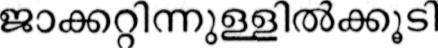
ജാക്കറ്റിന്നുള്ളില്‍ക്കൂടി
